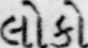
લોકો
